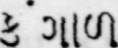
કંગાળ
